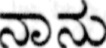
ನಾನು
